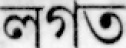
লগত
